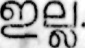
ഇല്ല.
